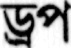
ড্রপ
